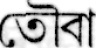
তৌবা
